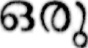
ഒരു
